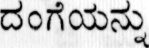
ದಂಗೆಯನ್ನು
